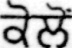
ਕੋਲੋਂ
